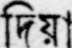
দিয়া
